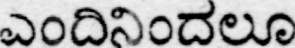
ಎಂದಿನಿಂದಲೂ
